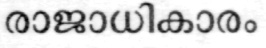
രാജാധികാരം
